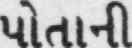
પોતાની
